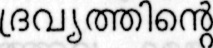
ദ്രവ്യത്തിന്റെ
